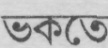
ভকতে
